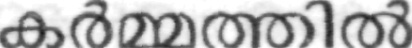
കര്‍മ്മത്തില്‍
